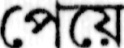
পেয়ে
